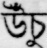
উঁচু
